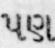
પણ
